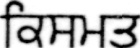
ਕਿਸਮਤ
